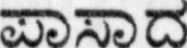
ಪಾಸಾದ
